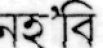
নহ'বি
